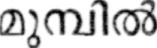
മുമ്പില്‍
